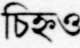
চিহ্নও
